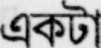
একটা
